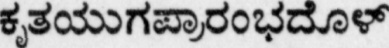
ಕೃತಯುಗಪ್ರಾರಂಭದೊಳ್
